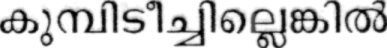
കുമ്പിടീച്ചില്ലെങ്കില്‍
